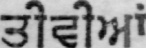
ਤੀਵੀਆਂ
